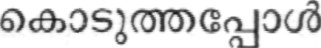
കൊടുത്തപ്പോള്‍
